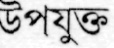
উপযুক্ত
